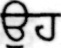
ਉਹ
